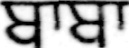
ਬਾਬਾ
